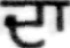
ਦਾ
